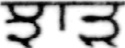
ਝਾੜ
